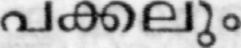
പക്കലും
